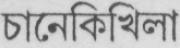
চানেকিখিলা
